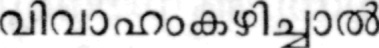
വിവാഹംകഴിച്ചാല്‍
